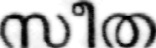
സീത
